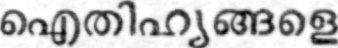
ഐതിഹ്യങ്ങളെ
